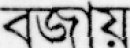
বজায়
